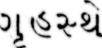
ગૃહસ્થે
